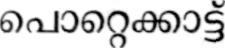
പൊറ്റെക്കാട്ട്
